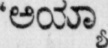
‘ಅಯ್ಯಾ
